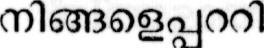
നിങ്ങളെപ്പററി
